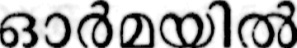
ഓര്‍മയില്‍
